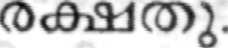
രക്ഷതു.
